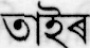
তাইৰ
